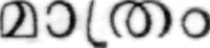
മാത്രം
